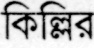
কিল্লির
